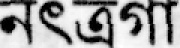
নৎত্রগা
